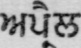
ਅਪ੍ਰੈਲ
